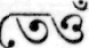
তেওঁ
